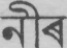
নীৰ
